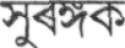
সুৰঙ্গক
